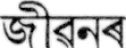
জীৱনৰ
